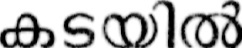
കടയില്‍
